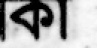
মকা
